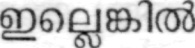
ഇല്ലെങ്കില്‍
